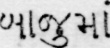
બાજુમાં
